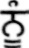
ਨੂੰ
